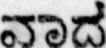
ವಾದ
